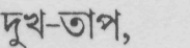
দুখ-তাপ,
